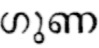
ഗുണ
